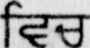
ਵਿਚ
